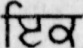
ਇਕ
